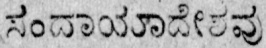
ಸಂದಾಯಾದೇಶವು
